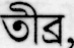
তীব্র,
